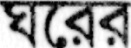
ঘরের
